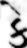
કે
